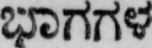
ಭಾಗಗಳ
